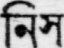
নিস
